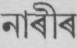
নাৰীৰ
